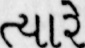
ત્યારે
